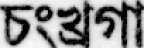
চংখ্রগা
